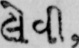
લેવી,
